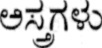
ಅಸ್ತ್ರಗಳು
